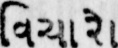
વિચારો
